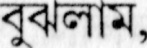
বুঝলাম,
